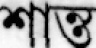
শান্ত
